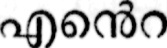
എന്റെ
